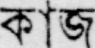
কাজ
